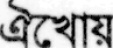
ঐখোয়
